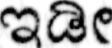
ಇಡೀ
